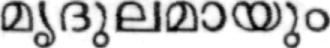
മൃദുലമായും
